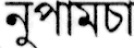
নুপামচা
